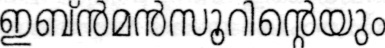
ഇബ്ന്‍മന്‍സൂറിൻ്റെയും
